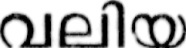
വലിയ
